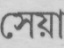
সেয়া
